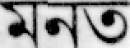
মনত
